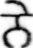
ਨੇ
